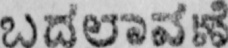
ಬದಲಾವಣೆ
